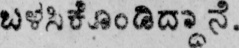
ಬಳಸಿಕೊಂಡಿದ್ದಾನೆ.
